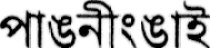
পাঙনীংঙাই
